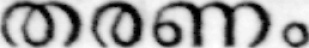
തരണം
